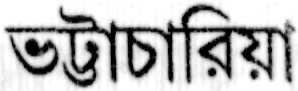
ভট্টাচারিয়া
